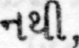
નથી,
